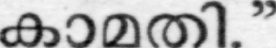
കാമതി.”
